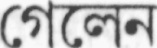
গেলেন
